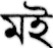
মই
